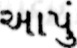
આપું
